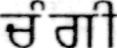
ਚੰਗੀ
